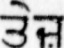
ਤੇਜ਼
